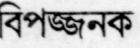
বিপজ্জনক
